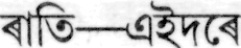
ৰাতি-এইদৰে
